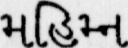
મહિન્મ
